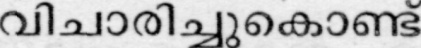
വിചാരിച്ചുകൊണ്ട്
